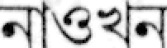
নাওখন
